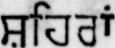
ਸ਼ਹਿਰਾਂ
